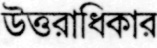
উত্তরাধিকার
